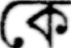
কে
